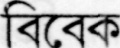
বিবেক
